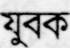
যুবক
